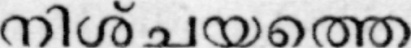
നിശ്ചയത്തെ
